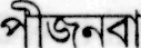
পীজনবা
